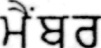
ਮੈਂਬਰ
